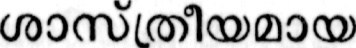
ശാസ്ത്രീയമായ
